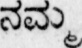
ನಮ್ಮ
